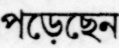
পড়েছেন
